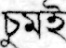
চুমই
